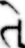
તે
